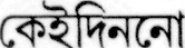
কেইদিননো
